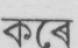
কৰে
